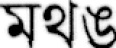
মথঙ
